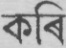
কৰি
